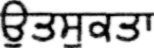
ਉਤਸੁਕਤਾ
